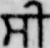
ਸੀ
